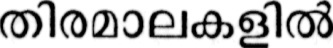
തിരമാലകളില്‍
